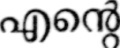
എന്റെ
